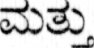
ಮತ್ತು
